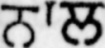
ਨਾਲ
